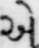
એ
